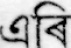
এৰি
